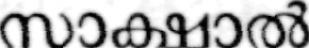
സാക്ഷാല്‍
